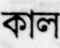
কাল
